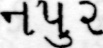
નપુર
